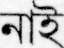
নাই
